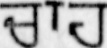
ਚਾਹ
